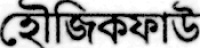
হৌজিকফাউ
